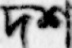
দশ
